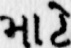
માટે
